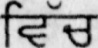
ਵਿੱਚ
